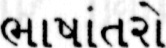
ભાષાંતરો
